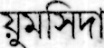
য়ুমসিদা
